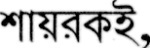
শায়রকই,
